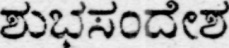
ಶುಭಸಂದೇಶ
